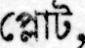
প্লোট,
